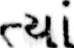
ત્યાં
